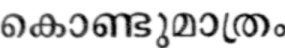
കൊണ്ടുമാത്രം
